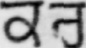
ਕਰ
